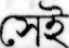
সেই
